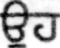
ਉਹ
